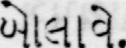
બોલાવે.
